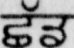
ਛੱਡ
